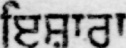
ਇਸ਼ਾਰਾ
